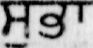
ਸੁਭਾ
